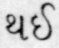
થઈ
